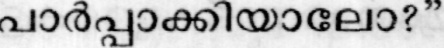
പാര്‍പ്പാക്കിയാലോ?"
